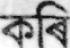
কৰি
